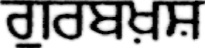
ਗੁਰਬਖ਼ਸ਼
